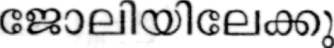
ജോലിയിലേക്കു
